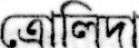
ত্রোলিদা
